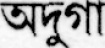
অদুগা
